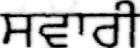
ਸਵਾਰੀ
